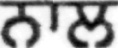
ਨਾਲ
